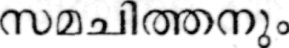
സമചിത്തനും
